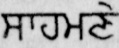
ਸਾਹਮਣੇ
